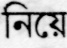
নিয়ে
